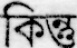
কিন্তু
